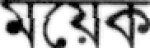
ময়েক
